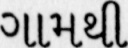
ગામથી
